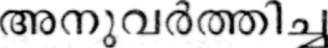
അനുവര്‍ത്തിച്ച
